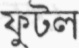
ফুটল
